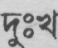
দুঃখ
